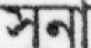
সনা
